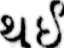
થઈ
